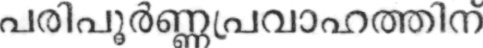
പരിപൂര്‍ണ്ണപ്രവാഹത്തിന്
